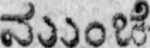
ಮುಂಚೆ
